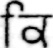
ਕਿ
